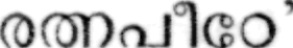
രത്നപീഠേ'
